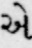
એ
